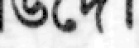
খঙদে
